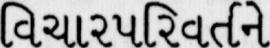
વિચારપરિવર્તને
